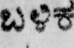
ಬಳಿಕ
